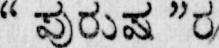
“ಪುರುಷ”ರ
